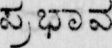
ಪ್ರಭಾವ
